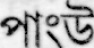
পাংউ
